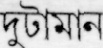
দুটামান
